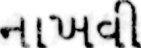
નાખવી
